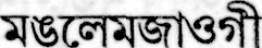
মঙলেমজাওগী
